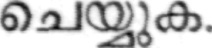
ചെയ്യുക.
